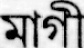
মাগী
